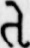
તે
